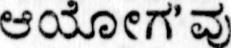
ಆಯೋಗ’ವು
